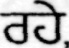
ਰਹੇ,
